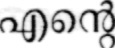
എന്റെ
